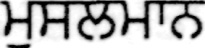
ਮੁਸਲਮਾਨ
